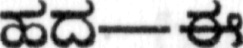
ಹದ-ಈ
